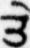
ਤੇ
